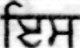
ਇਸ
